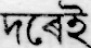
দৰেই
